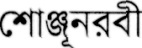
শোঞ্জূনরবী
